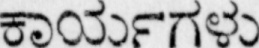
ಕಾರ್ಯಗಳು
